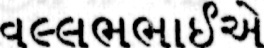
વલ્લભભાઈએ
